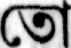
তো
